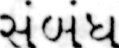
સંબંધ
